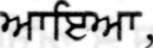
ਆਇਆ,
